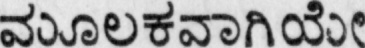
ಮೂಲಕವಾಗಿಯೇ
